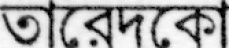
তারেদকো
